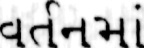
વર્તનમાં
